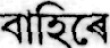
বাহিৰে
